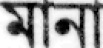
মানা
